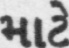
માટે
